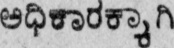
ಅಧಿಕಾರಕ್ಕಾಗಿ
